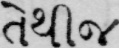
તેથીજ
